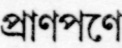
প্রাণপণে
